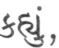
કહ્યું,
